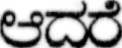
ಆದರೆ
